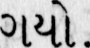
ગયો.
